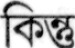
কিন্তু
